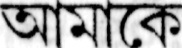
আমাকে
